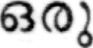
ഒരു
